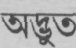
অদ্ভুত
